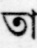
তা
